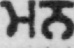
ਮਨ
